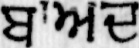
ਬਾਅਦ
